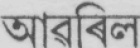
আৱৰিল
